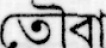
তৌবা
